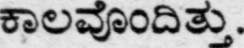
ಕಾಲವೊಂದಿತ್ತು.
